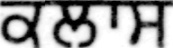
ਕਲਾਸ
